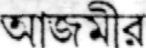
আজমীর
